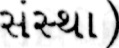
સંસ્થા)
